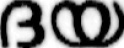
ദയ
